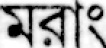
মরাং
